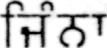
ਜਿੰਨਾ
